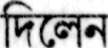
দিলেন
